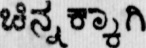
ಚಿನ್ನಕ್ಕಾಗಿ
